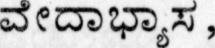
ವೇದಾಭ್ಯಾಸ,
